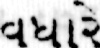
વધારે
